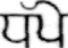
ਧੱਪੇ
